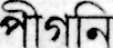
পীগনি
